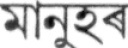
মানুহৰ
